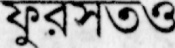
ফুরসতও
